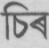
চিৰ
